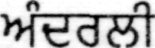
ਅੰਦਰਲੀ
